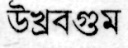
উখ্রবগুম
